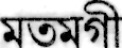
মতমগী
